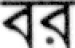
বর
